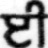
ਈ
